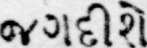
જગદીશે
